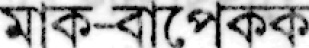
মাক-বাপেকক
